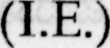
(I.E.)
